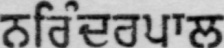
ਨਰਿੰਦਰਪਾਲ
